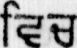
ਵਿਚ
